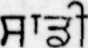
ਸਾਡੀ
